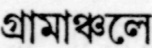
গ্রামাঞ্চলে
